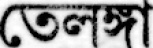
তেলঙ্গা
